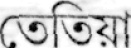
তেতিয়া
